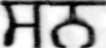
ਸਨ
